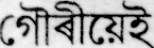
গৌৰীয়েই
